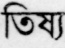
তিষ্য
